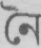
নৈ
